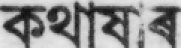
কথাষাৰ
